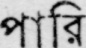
পারি
